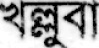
খল্লুবা
